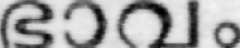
ഭാവം
